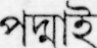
পদ্মাই
